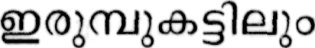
ഇരുമ്പുകട്ടിലും
